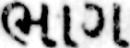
ભાગ
